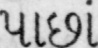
પાછાં
